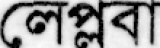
লেপ্লবা
